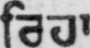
ਰਿਹਾ
